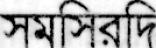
সমসিরদি
